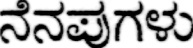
ನೆನಪುಗಳು
